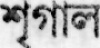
শৃগাল
